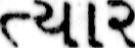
ત્યાર
